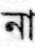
না
